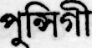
পুন্সিগী
